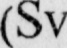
(Sv
